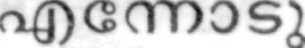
എന്നോടു
